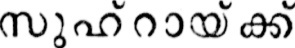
സുഹ്റായ്ക്ക്
